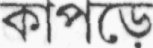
কাপড়ে
